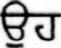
ਉਹ
